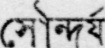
সৌন্দর্য
